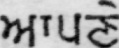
ਆਪਣੇ
